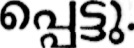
പ്പെട്ടു.
